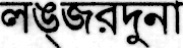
লঙ্জরদুনা
